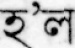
হ'ল
